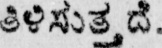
ತಿಳಿಸುತ್ತದೆ.
